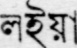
লইয়া
